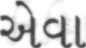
એવા
